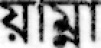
য়াম্না
